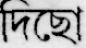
দিছো
